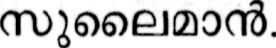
സുലൈമാന്‍.
